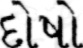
દોષો
